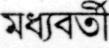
মধ্যবর্তী
